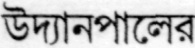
উদ্যানপালের
